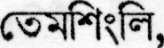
তেমশিংলি,
